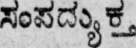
ಸಂಪದ್ಯುಕ್ತ
